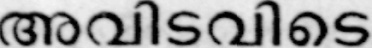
അവിടവിടെ
